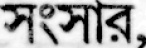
সংসার,
